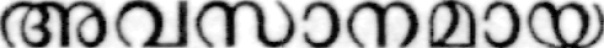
അവസാനമായ
